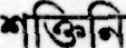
শক্তিনি
